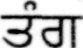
ਤੰਗ
